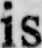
is
